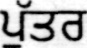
ਪੁੱਤਰ
